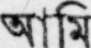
আমি
